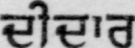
ਦੀਦਾਰ
